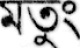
মতুং
